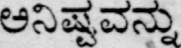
ಅನಿಷ್ಟವನ್ನು
